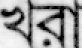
খরা
